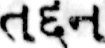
તદ્દન
